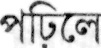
পঢ়িলে
